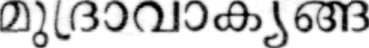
മുദ്രാവാക്യങ്ങ
